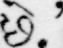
છે.'
